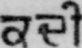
ਕਦੀ
